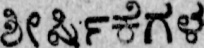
ಶೀರ್ಷಿಕೆಗಳ
